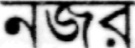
নজর
